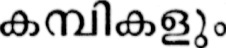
കമ്പികളും
